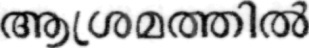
ആശ്രമത്തില്‍
